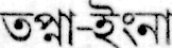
তপ্না-ইংনা
